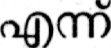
എന്ന്
